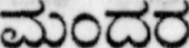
ಮಂದರ
